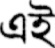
এই
